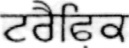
ਟਰੈਫ਼ਿਕ
